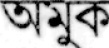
অমুক
